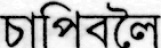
চাপিবলৈ
